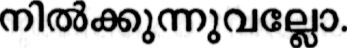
നില്‍ക്കുന്നുവല്ലോ.
